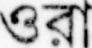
ওরা
